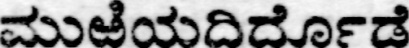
ಮುೞೆಯದಿರ್ದೊಡೆ
